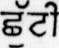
ਛੁੱਟੀ
